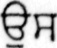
ਉਸ
